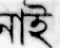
নাই
